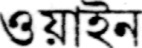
ওয়াইন
